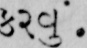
કરવું.
